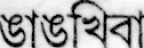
ঙাঙখিবা
